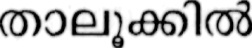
താലൂക്കില്‍
